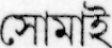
সোমাই
